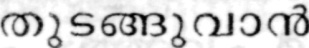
തുടങ്ങുവാന്‍
